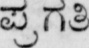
ಪ್ರಗತಿ
